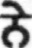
ਨੇ
